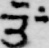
ਤੋਂ
